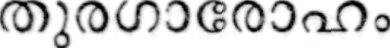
തുരഗാരോഹം
